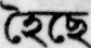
হৈছে
